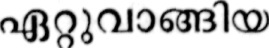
ഏറ്റുവാങ്ങിയ
